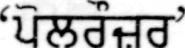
'ਪੋਲਰੌਜ਼ਰ'
